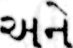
અને
